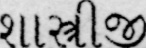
શાસ્ત્રીજી
